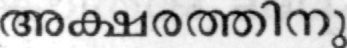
അക്ഷരത്തിനു
